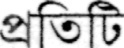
প্রতিটি
